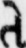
તે
